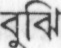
বুঝি
